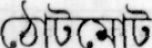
ঠোটমোট
